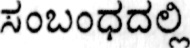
ಸಂಬಂಧದಲ್ಲಿ
